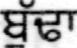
ਬੁੱਢਾ
